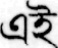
এই
